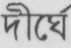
দীৰ্ঘে
